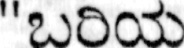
“ಬರಿಯ
